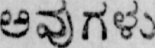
ಅವುಗಳು
